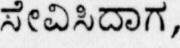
ಸೇವಿಸಿದಾಗ,
